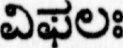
ವಿಫಲಃ
